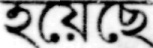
হয়েছে
